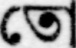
তো
